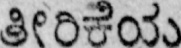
ತೀರಿಕೆಯ
